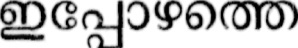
ഇപ്പോഴത്തെ
